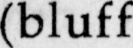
(bluff
